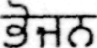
ਭੋਜਨ
